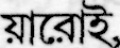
য়ারোই,
